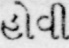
હોવી
